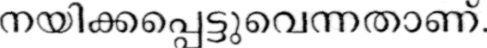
നയിക്കപ്പെട്ടുവെന്നതാണ്.
